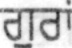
ਗੁਰਾਂ
